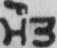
ਮੌਤ
